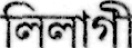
লিলাগী
